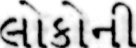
લોકોની
